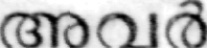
അവര്‍
